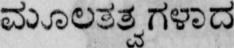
ಮೂಲತತ್ವಗಳಾದ
